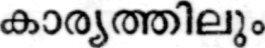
കാര്യത്തിലും
